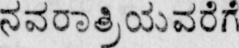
ನವರಾತ್ರಿಯವರೆಗೆ
